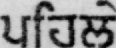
ਪਹਿਲੇ
